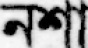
নশা
